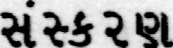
સંસ્કરણ
